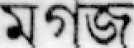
মগজ
